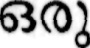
ഒരു
